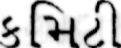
કમિટી
